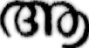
ആ
